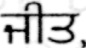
ਜੀਤ,
